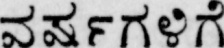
ವರ್ಷಗಳಿಗೆ
